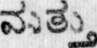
ಮತ್ತು
